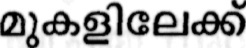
മുകളിലേക്ക്
